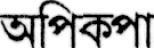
অপিকপা
